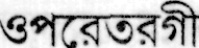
ওপরেতরগী
